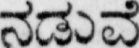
ನಡುವೆ
